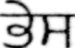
ਭੇਸ
